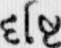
દષ્ટિ
